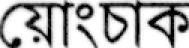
য়োংচাক
